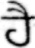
ਹੈ
